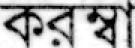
করম্বা
